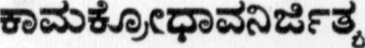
ಕಾಮಕ್ರೋಧಾವನಿರ್ಜಿತ್ಯ
